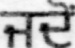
ਜਦੋਂ
